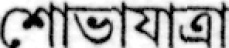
শোভাযাত্রা
